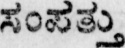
ಸಂಪತ್ತು
